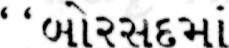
"બોરસદમાં
